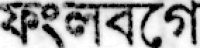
ফংলবগে
